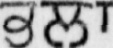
ਭਲਾ
